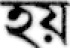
হয়
